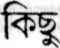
কিছু
